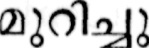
മുറിച്ചു
